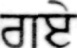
ਗਏ
